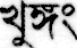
খুঙ্গং
